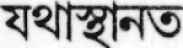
যথাস্থানত
